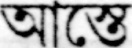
আস্তে
